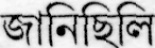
জানিছিলি
